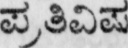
ಪ್ರತಿವಿಷ
